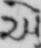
એ
